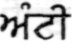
ਅੰਟੀ
